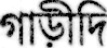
গাড়ীদি
